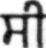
ਸੀ
